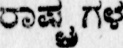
ರಾಷ್ಟ್ರಗಳ
